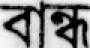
বান্ধ
